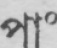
পা
